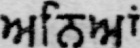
ਅਨਿਆਂ
